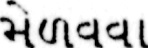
મેળવવા
